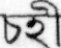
চহী
